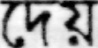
দেয়
